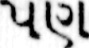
પણ
